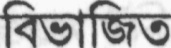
বিভাজিত
